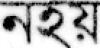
নহয়
